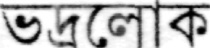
ভদ্রলোক
